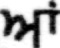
ਆਂ
